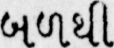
બળથી
